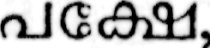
പക്ഷേ,
